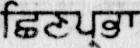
ਛਿਣਪ੍ਰਭਾ
